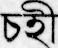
চহী
